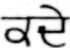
ਕਦੇ
